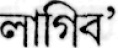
লাগিব'
